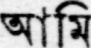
আমি
